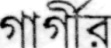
গার্গীর
